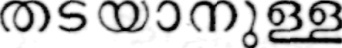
തടയാനുള്ള
